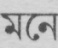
মনে
